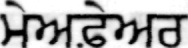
ਮੇਅਫ਼ੇਅਰ
